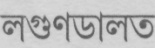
লগুণডালত
